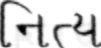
નિત્ય
